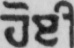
ਹੋਈ
